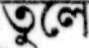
তুলে
